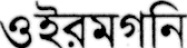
ওইরমগনি
